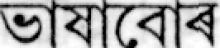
ভাষাবোৰ
